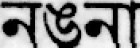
নঙনা
